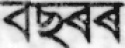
বছৰৰ
